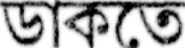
ডাকতে
